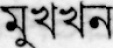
মুখখন
